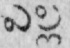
ಎಲ್ಲ
